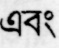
এবং
